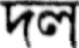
দল
